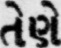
તેણે
